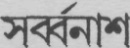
সৰ্ব্বনাশ
